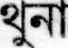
থুনা
